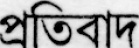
প্রতিবাদ
